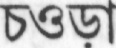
চওড়া
